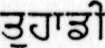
ਤੁਹਾਡੀ
